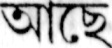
আছে
